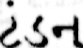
ટંડન
